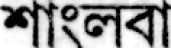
শাংলবা
